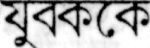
যুবককে
